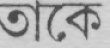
তাকে
